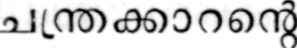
ചന്ത്രക്കാറന്റെ
